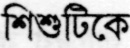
শিশুটিকে
